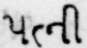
પત્ની
